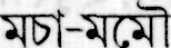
মচা-মমৌ
